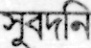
সুবদনি
